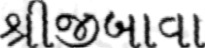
શ્રીજીબાવા
